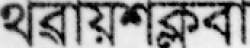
থৱায়শক্লবা
